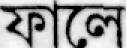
ফালে
